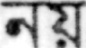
নয়
